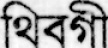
থিবগী
